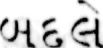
બદલે
